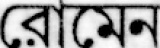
রোমেন
